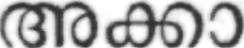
അക്കാ
